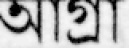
আগ্রা
